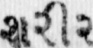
શરીર
